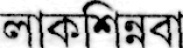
লাকশিন্নবা
